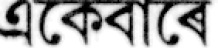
একেবাৰে
